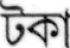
টকা
